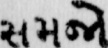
સમજો
